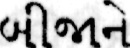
બીજાને
